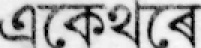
একেথৰে
